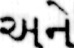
અને
